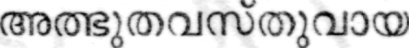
അത്ഭുതവസ്തുവായ
